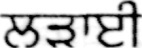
ਲੜਾਈ
